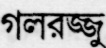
গলরজ্জু
